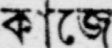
কাজে
